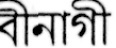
বীনাগী
